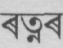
ৰত্নৰ
